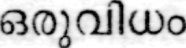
ഒരുവിധം
